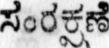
ಸಂರಕ್ಷಣೆ
